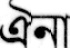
ঐনা
